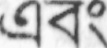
এবং
